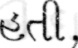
હતી,
